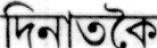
দিনাতকৈ
